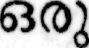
ഒരു
